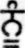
ਨੂੰ
